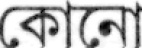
কোনো
